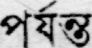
পর্যন্ত
